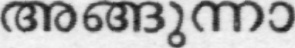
അങ്ങുന്നാ
